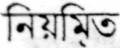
নিয়মিত
